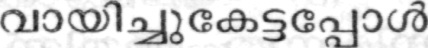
വായിച്ചുകേട്ടപ്പോള്‍
